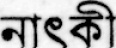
নাৎকী
